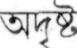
অদৃষ্ট
